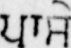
ਪਾਸੇ
